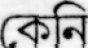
কেনি
